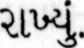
રાખ્યું.
